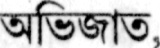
অভিজাত,
